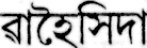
ৱাহৈসিদা
